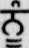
ਨੂੰ
